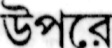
উপরে
